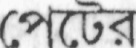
পেটের
